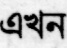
এখন
